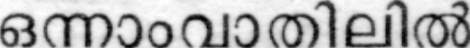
ഒന്നാംവാതിലില്‍
